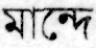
মান্দে
